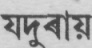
যদুৰায়
